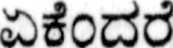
ಏಕೆಂದರೆ
